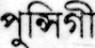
পুন্সিগী
